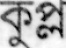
কুপ্ল
